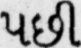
પછી
